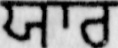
ਯਾਰ
